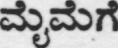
ಮೈಮೆಗೆ
